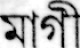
মাগী
